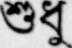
শুধু
